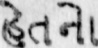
હેતનો
